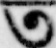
ত
